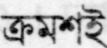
ক্রমশই
